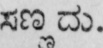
ಸಣ್ಣದು.
